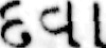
દવા
